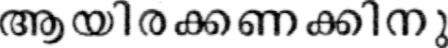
ആയിരക്കണക്കിനു
